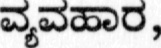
ವ್ಯವಹಾರ,
